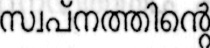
സ്വപ്നത്തിന്റെ
